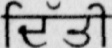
ਦਿੱਤੀ
